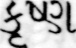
કૃષ્ણ
